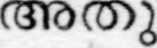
അതു
